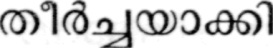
തീര്‍ച്ചയാക്കി
